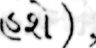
હશે),
